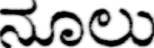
ನೂಲು
